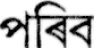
পৰিব
